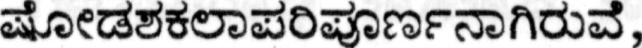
ಷೋಡಶಕಲಾಪರಿಪೂರ್ಣನಾಗಿರುವೆ,
